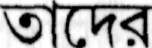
তাদের
